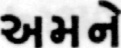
અમને
